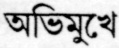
অভিমুখে
